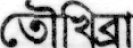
তৌখিব্রা
